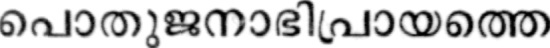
പൊതുജനാഭിപ്രായത്തെ
